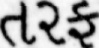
તરફ
